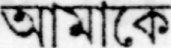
আমাকে
